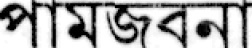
পামজবনা
